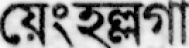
য়েংহল্লগা
